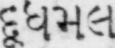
દૂધમલ
